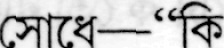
সোধে-"কি
